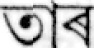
তাৰ
